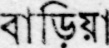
বাড়িয়া
